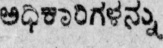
ಅಧಿಕಾರಿಗಳನ್ನು
